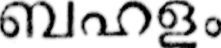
ബഹളം
